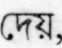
দেয়,
